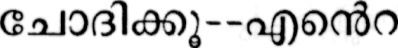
ചോദിക്കൂ--എൻെറ
